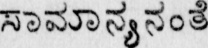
ಸಾಮಾನ್ಯನಂತೆ
